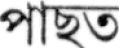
পাছত
